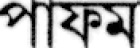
পাফম
